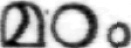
മഠം
